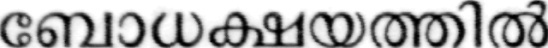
ബോധക്ഷയത്തില്‍
